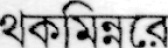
থকমিন্নরে
